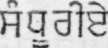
ਸੰਧੂਰੀਏ
